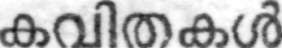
കവിതകള്‍
